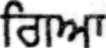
ਗਿਆ
